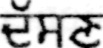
ਦੱਸਣ
